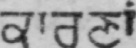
ਕਾਰਣਾਂ
